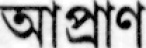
আপ্রাণ
